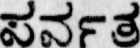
ಪರ್ವತ
